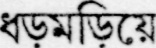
ধড়মড়িয়ে
